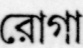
রোগা
